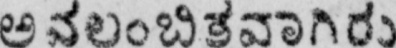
ಅವಲಂಬಿತವಾಗಿರು
